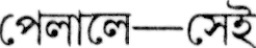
পেলালে-সেই
